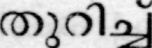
തുറിച്ച്
